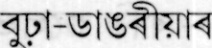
বুঢ়া-ডাঙৰীয়াৰ
